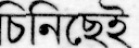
চিনিছেই
